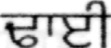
ਢਾਈ
